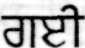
ਗਈ
